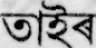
তাইৰ
